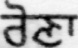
ਰੋਣਾ
